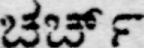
ಚರ್ಚ್
